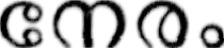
നേരം
